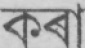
কৰা
